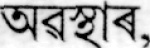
অৱস্হাৰ,
